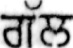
ਗੱਲ
